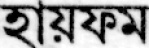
হায়ফম
